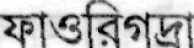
ফাওরিগদ্রা
